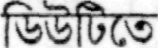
ডিউটিতে
